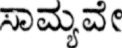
ಸಾಮ್ಯವೇ
